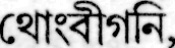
থোংবীগনি,
